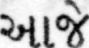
આજે
